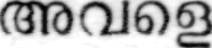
അവളെ
